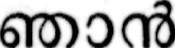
ഞാന്‍
